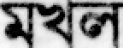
মখল
